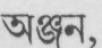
অঞ্জন,
